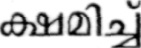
ക്ഷമിച്ച്
